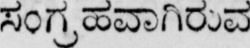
ಸಂಗ್ರಹವಾಗಿರುವ
